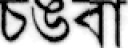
চঙবা
